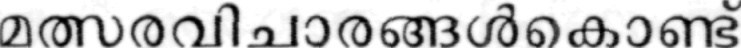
മത്സരവിചാരങ്ങള്‍കൊണ്ട്
